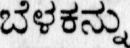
ಬೆಳಕನ್ನು
